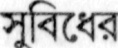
সুবিধের
